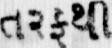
તરફથી
